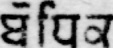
ਬੋਧਿਕ
